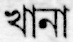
খানা
